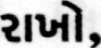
રાખો,
